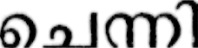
ചെന്നി
